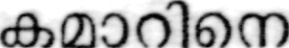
കമാറിനെ
